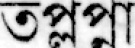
তপ্লপ্না
